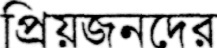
প্রিয়জনদের
